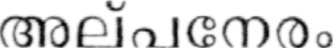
അല്പനേരം
